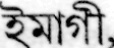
ইমাগী,
